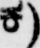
ಕ)
